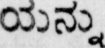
ಯನ್ನು
